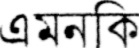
এমনকি
